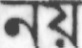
নয়
